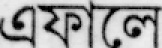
এফালে
